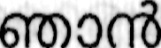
ഞാന്‍
